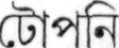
টোপনি
